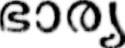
ഭാര്യ
